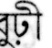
বুঢ়ী
